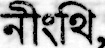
নীংথি,
